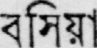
বসিয়া
